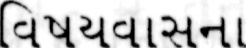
વિષયવાસના
